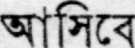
আসিবে
